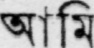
আমি
